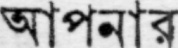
আপনার
